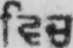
ਵਿਚ
